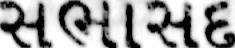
સભાસદ
